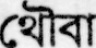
থৌবা
